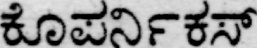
ಕೊಪರ್ನಿಕಸ್
